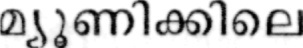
മ്യൂണിക്കിലെ
